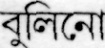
বুলিনো
